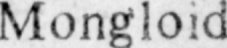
Mongloid
